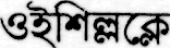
ওইশিল্লক্লে
